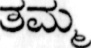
ತಮ್ಮ
